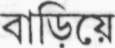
বাড়িয়ে
